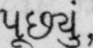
પૂછ્યું,
